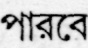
পারবে
